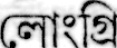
লোংগ্রি
